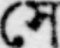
সে
